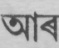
আৰ
